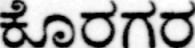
ಕೊರಗರ
